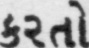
કરતો
